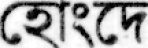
হোংদে
